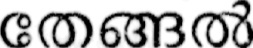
തേങ്ങല്‍
